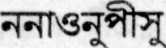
ননাওনুপীসু
